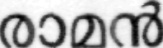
രാമന്‍
